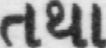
તથા
